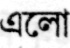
এলো
